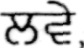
ਲਵੇ,
